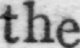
the
